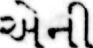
એની
